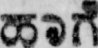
ಹಾಗೆ
